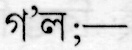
গ'ল;-
